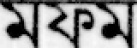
মফম
